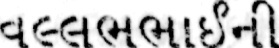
વલ્લભભાઈની
